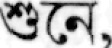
শুনে,
